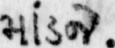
માંડજે.
